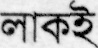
লাকই
